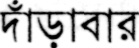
দাঁড়াবার
